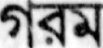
গরম
